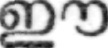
ഈ
